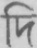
দি
